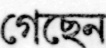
গেছেন
